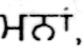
ਮਨਾਂ,
